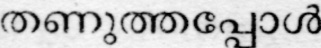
തണുത്തപ്പോള്‍
